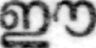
ഈ
